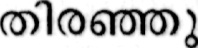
തിരഞ്ഞു
